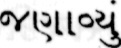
જણાવ્યું
